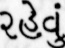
રહેવું
